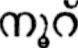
നൂറ്
